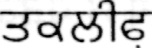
ਤਕਲੀਫ਼
